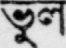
ভুল
